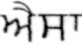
ਐਸਾ
